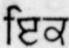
ਇਕ
